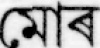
মোৰ
